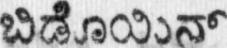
ಬಿಡೊಯಿನ್
